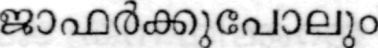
ജാഫര്‍ക്കുപോലും
